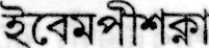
ইবেমপীশক্না
